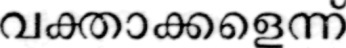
വക്താക്കളെന്ന്
